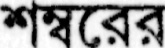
শম্বরের
